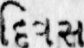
દિવસ
